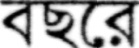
বছরে
